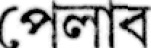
পেলাব
